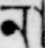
না
